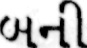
બની
